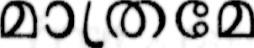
മാത്രമേ
